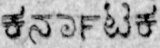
ಕರ್ನಾಟಕ
